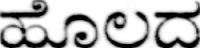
ಹೊಲದ
